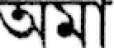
অমা
